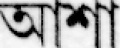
আশা
